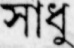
সাধু
